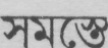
সমস্তে
